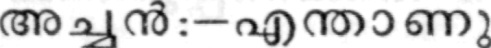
അച്ചന്‍:-എന്താണു
